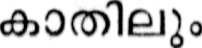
കാതിലും
